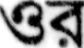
ওর
